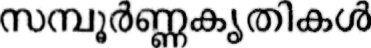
സമ്പൂര്‍ണ്ണകൃതികള്‍
